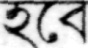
হবে
